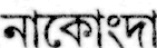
নাকোংদা
